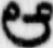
ಆ
